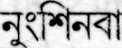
নুংশিনবা
